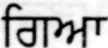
ਗਿਆ
